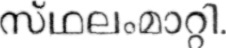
സ്ഥലംമാറ്റി.
